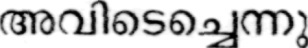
അവിടെച്ചെന്നു
